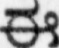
ಈ
